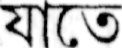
যাতে
